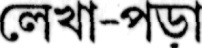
লেখা-পড়া
